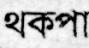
থকপা
